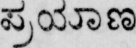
ಪ್ರಯಾಣ
